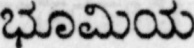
ಭೂಮಿಯ
